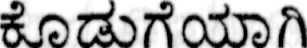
ಕೊಡುಗೆಯಾಗಿ
